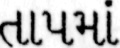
તાપમાં
